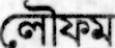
লৌফম
